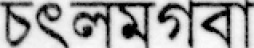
চৎলমগবা
